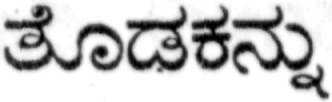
ತೊಡಕನ್ನು
